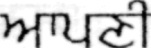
ਆਪਣੀ
